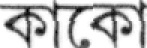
কাকো
